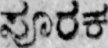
ಪೂರಕ
